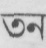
তন
